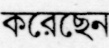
করেছেন
